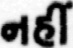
નહીં
